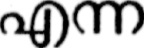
എന്ന
